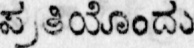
ಪ್ರತಿಯೊಂದು
